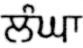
ਲੰਘਾ
